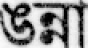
ঙন্না
